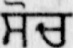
ਸੋਚ
